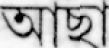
আছা
